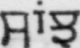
ਸਾਂਝ
